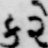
કરે
